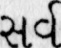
સર્વ
